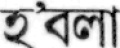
হ'বলা
